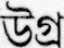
উগ্র
